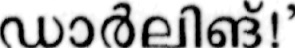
ഡാര്‍ലിങ്!’
